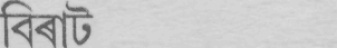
বিৰাট
